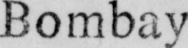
Bombay
